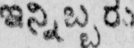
ಇನ್ನಿಬ್ಬರು
